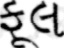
ફૂલ
